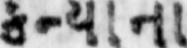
કન્યાના
